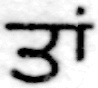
ਤਾਂ
